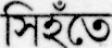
সিহঁতে
